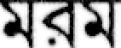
মরম
